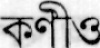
কণীও
